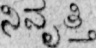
ನಿವೃತ್ತಿ
